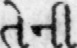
તેની
